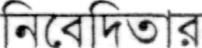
নিবেদিতার
